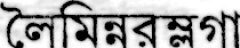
লৈমিন্নরম্লগা
